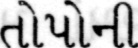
તોપોની
